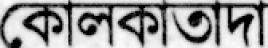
কোলকতাদা
